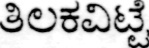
ತಿಲಕವಿಟ್ಟೆ
